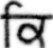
ਕਿ
